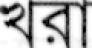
খরা
